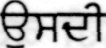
ਉਸਦੀ
